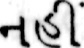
નહીં
